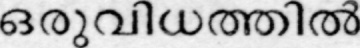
ഒരുവിധത്തില്‍
